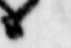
જ
